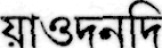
য়াওদনদি
